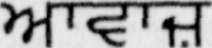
ਆਵਾਜ਼
